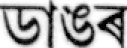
ডাঙৰ
